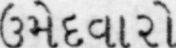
ઉમેદવારો
